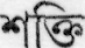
শক্তি
